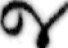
જ
